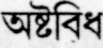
অষ্টবিধ
